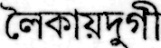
লৈকায়দুগী
